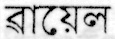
ৱায়েল
